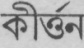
কীৰ্ত্তন
